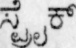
ಸ್ಟ್ರೈಕ್
